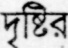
দৃষ্টির
